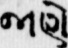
જાણે
